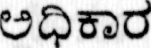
ಅಧಿಕಾರ
